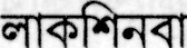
লাকশিনবা
